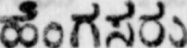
ಹೆಂಗಸರು
